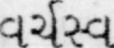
વર્ચસ્વ
